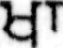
ਖਾ
